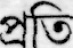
প্রতি
